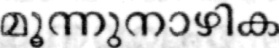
മൂന്നുനാഴിക
